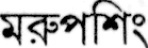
মরুপশিং
